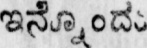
ಇನ್ನೊಂದು
